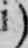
i)
